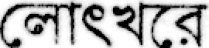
লোৎখরে
